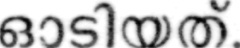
ഓടിയത്.
